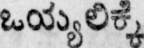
ಒಯ್ಯಲಿಕ್ಕೆ
